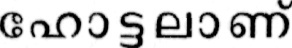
ഹോട്ടലാണ്
